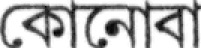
কোনোবা
